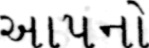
આપનો
